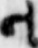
ન
